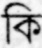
কি
